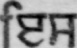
ਇਸ
